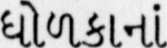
ધોળકાનાં
